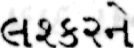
લશ્કરને
